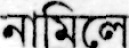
নামিলে
